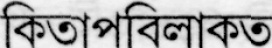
কিতাপবিলাকত
